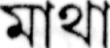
মাথা
